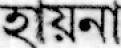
হায়না
